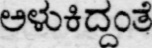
ಅಳುಕಿದ್ದಂತೆ
